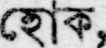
হোক,
